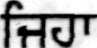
ਜਿਹਾ
